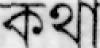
কথা
